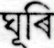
ঘূৰি
